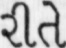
રીતે
